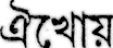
ঐখোয়
